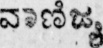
ವಾಣಿಜ್ಯ
